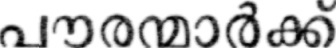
പൌരന്മാര്‍ക്ക്
